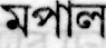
মপাল
